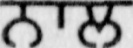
ਨਾਲ
